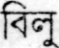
বিলু
